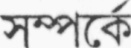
সম্পর্কে
